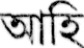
আহি
